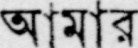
আমার
